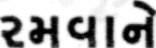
રમવાને
